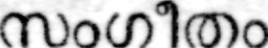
സംഗീതം
